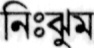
নিঃঝুম
